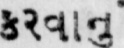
કરવાનું
